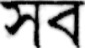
সব
